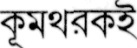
কূমথরকই
